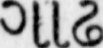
ગાઢ
